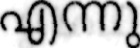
എന്നു
